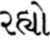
રહ્યો
